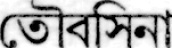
তৌবসিনা
